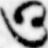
ও
